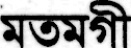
মতমগী
